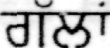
ਗੱਲਾਂ
